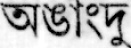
অঙাংদু
